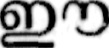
ഈ
